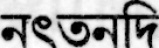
নৎতনদি
